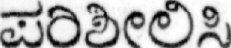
ಪರಿಶೀಲಿಸಿ
